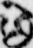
છે
